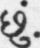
છું.
